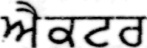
ਐਕਟਰ
